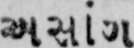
અસાંગ
